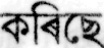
কৰিছে
